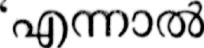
'എന്നാല്‍
